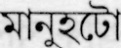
মানুহটো
